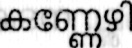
കണ്ണേഴി
